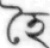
হৈ
